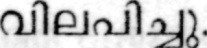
വിലപിച്ചു.
